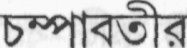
চম্পাবতীর
